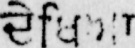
ਦੇਖਿਆ
